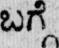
ಬಗ್ಗೆ
